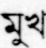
মুখ
